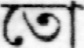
তো
